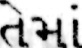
તેમાં
